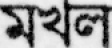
মখল
